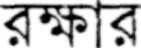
রক্ষার
